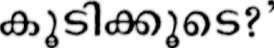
കൂടിക്കൂടെ?’
